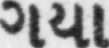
ગયા
